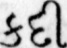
કદી
